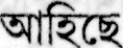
আহিছে
